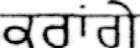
ਕਰਾਂਗੇ
